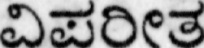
ವಿಪರೀತ
